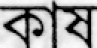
কাষ
